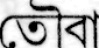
তৌবা
